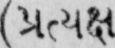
(પ્રત્યક્ષ
